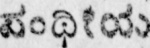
ಪಂಥೀಯ
